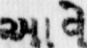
આવે
